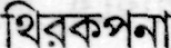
থিরকপা
